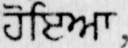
ਹੋਇਆ,
